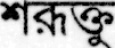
শরূক্তু
